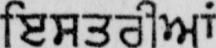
ਇਸਤਰੀਆਂ
